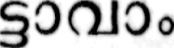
ട്ടാവാം
